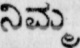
ನಿಮ್ಮ
